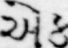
એક
